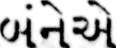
બંનેએ
